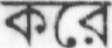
করে
